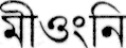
মীওংনি
